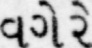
વગેરે
